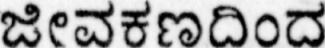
ಜೀವಕಣದಿಂದ
